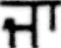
ਜਾ
